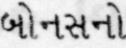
બોનસનો
